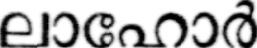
ലാഹോര്‍
